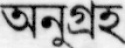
অনুগ্রহ
